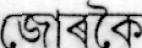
জোৰকৈ
